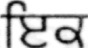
ਇਕ
